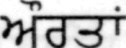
ਔਰਤਾਂ
